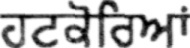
ਹਟਕੋਰਿਆਂ
